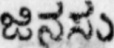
ಜಿನಸು
